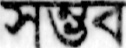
সম্ভব
